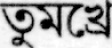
তুমখ্রে
